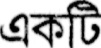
একটি
